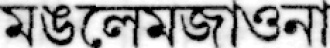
মঙলেমজাওনা
